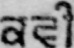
ਕਵੀ
